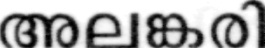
അലങ്കരി
